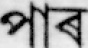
পাৰ
